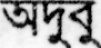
অদুবু
